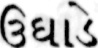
ઉઘાડે
